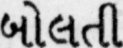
બોલતી
